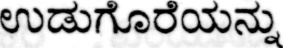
ಉಡುಗೊರೆಯನ್ನು
